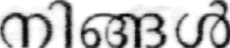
നിങ്ങള്‍
